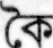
কৈ
